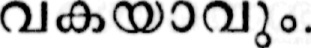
വകയാവും.
